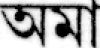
অমা
